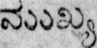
ಮುಖ್ಯ
